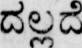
ದಲ್ಲದೆ
